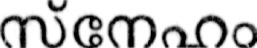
സ്നേഹം
